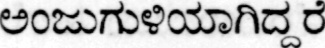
ಅಂಜುಗುಳಿಯಾಗಿದ್ದರೆ
